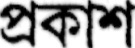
প্রকাশ
